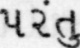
પરંતુ
